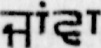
ਜਾਂਵਾ
